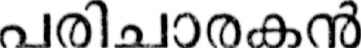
പരിചാരകന്‍
